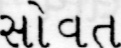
સોવત
